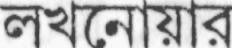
লখনোয়ার
